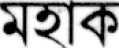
মহাক
